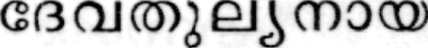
ദേവതുല്യനായ
